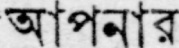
আপনার
